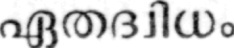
ഏതദ്വിധം
